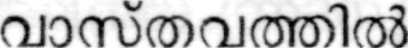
വാസ്തവത്തില്‍
